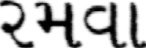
રમવા
